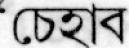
'চেহাব
